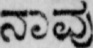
ನಾವು
